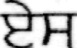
ਏਸ
